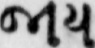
જાય
